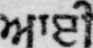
ਆਈ
